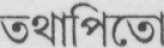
তথাপিতো
